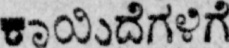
ಕಾಯಿದೆಗಳಿಗೆ
